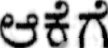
ಆಕೆಗೆ
